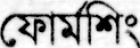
ফোর্মশিং
